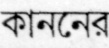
কাননের
